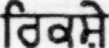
ਰਿਕਸ਼ੇ
